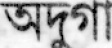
অদুগা
